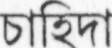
চাহিদা
